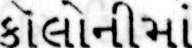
કૉલોનીમાં
